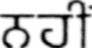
ਨਹੀਂ
